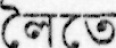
লৈতে
